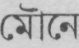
মৌনে
